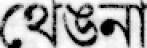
থেঙনা
